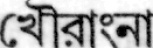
খৌরাংনা
